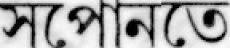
সপোনতে
